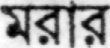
মরার
